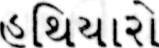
હથિયારો
